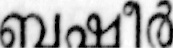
ബഷീര്‍
